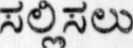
ಸಲ್ಲಿಸಲು
